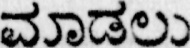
ಮಾಡಲು
